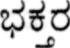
ಭಕ್ತರ
